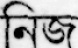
নিজ
